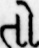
તો
